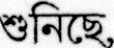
শুনিছে,
